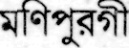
মণিপুরগী
